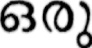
ഒരു
